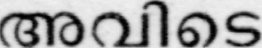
അവിടെ
